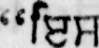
''ਇਸ
